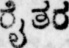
ರೈತರ
